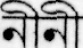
নীনী
